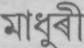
মাধুৰী
